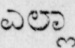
ಎಲ್ಲಾ
